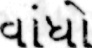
વાંધો
